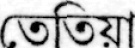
তেতিয়া
